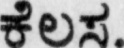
ಕೆಲಸ.
